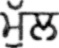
ਮੁੱਲ
